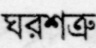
ঘরশত্রু
